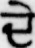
ਦੇ
